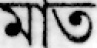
মাত
